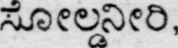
ಸೋಲ್ದನೀರಿ,
